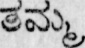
ತಮ್ಮ
